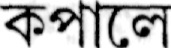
কপালে
